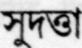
সুদত্তা
